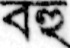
বহু
